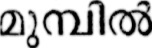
മുമ്പില്‍
